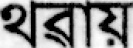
থৱায়
